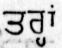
ਤਰ੍ਹਾਂ
